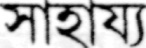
সাহায্য
